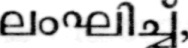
ലംഘിച്ച്,
